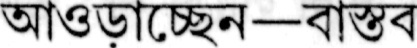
আওড়াচ্ছেন—বাস্তব
